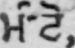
ਮੱਟੋ,
